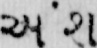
અંશ
